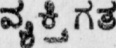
ವ್ಯಕ್ತಿಗತ
